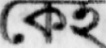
কেহ
